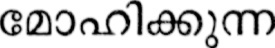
മോഹിക്കുന്ന
